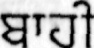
ਬਾਹੀ
